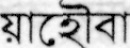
য়াহৌবা
